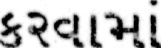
કરવામાં
